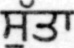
ਸੁੱਤਾ
